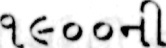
૧૯૦૦ની
